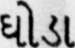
ઘોડા
